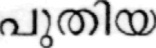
പുതിയ
